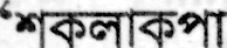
‘শকলাকপা
